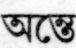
অন্তে
